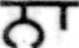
ਨਾ
